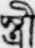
স্ত্রী
